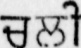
ਚਲੀ
